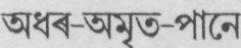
অধৰ-অমৃত-পানে
